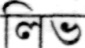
লিভ
